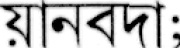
য়ানবদা;
